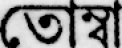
তোম্বা
